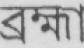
ব্রহ্মা
